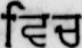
ਵਿਚ
